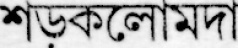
শড়কলোমদা
